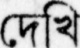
দেখি
